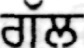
ਗੱਲ
